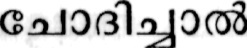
ചോദിച്ചാല്‍
